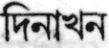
দিনাখন
